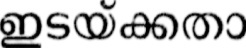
ഇടയ്ക്കതാ
